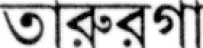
তারুরগা
